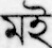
মই
